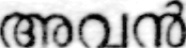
അവന്‍
